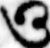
ও
